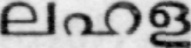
ലഹള
